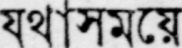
যথাসময়ে
